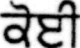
ਕੋਈ
